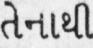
તેનાથી
